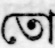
তো
